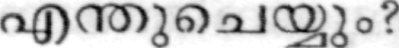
എന്തുചെയ്യും?
